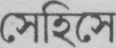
সেহিসে
